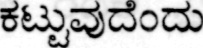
ಕಟ್ಟುವುದೆಂದು
